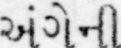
અંગેની
